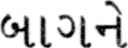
બાગને
